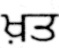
ਖ਼ਤ
